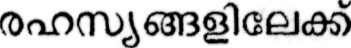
രഹസ്യങ്ങളിലേക്ക്
